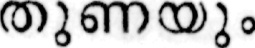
തുണയും
